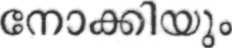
നോക്കിയും
